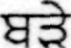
ਬੜੇ
